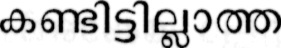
കണ്ടിട്ടില്ലാത്ത
